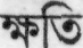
ক্ষতি
